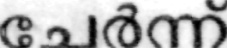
ചേര്‍ന്ന്
